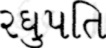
રઘુપતિ
